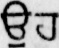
ਉਹ
